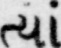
ત્યાં
